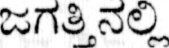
ಜಗತ್ತಿನಲ್ಲಿ
